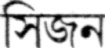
সিজন
